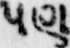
પણ
